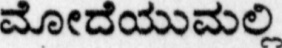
ಮೋದೆಯುಮಲ್ಲಿ
